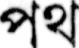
পথ
